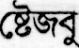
ষ্টেজবু
